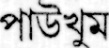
পাউখুম
